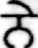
ਨੇ
